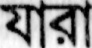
যারা
